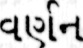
વર્ણન
